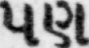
પણ
